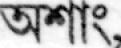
অশাং,
